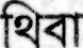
থিবা
